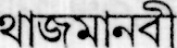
থাজমানবী
